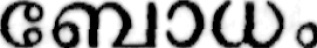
ബോധം
